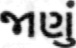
જાણું
